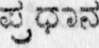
ಪ್ರಧಾನ
